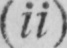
(ii)
